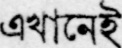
এখানেই
